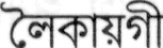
লৈকায়গী
